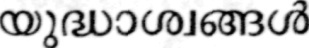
യുദ്ധാശ്വങ്ങള്‍
